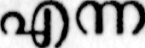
എന്ന
